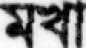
মখা
